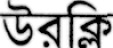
উরক্লি
